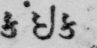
કંઈક
